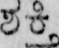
ಶಕ್ತಿ
